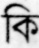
কি
